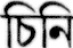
চিনি
